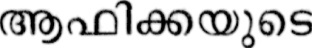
ആഫിക്കയുടെ
